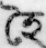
হৈ
